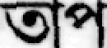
তাপ
